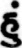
હું
